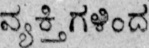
ವ್ಯಕ್ತಿಗಳಿಂದ
